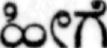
ಹೀಗೆ
